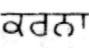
ਕਰਨਾ
